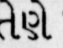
તેણે
